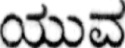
ಯುವ
